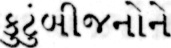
કુટુંબીજનોને
